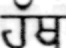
ਹੱਥ
